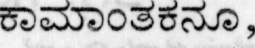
ಕಾಮಾಂತಕನೂ,
